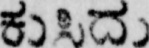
ಕುಸಿದು
